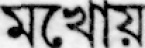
মখোয়
